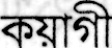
কয়াগী
